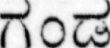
ಗಂಡ
